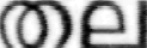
തല
